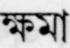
ক্ষমা
